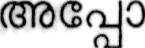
അപ്പോ
